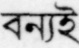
বন্যই
